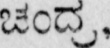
ಚಂದ್ರ,
